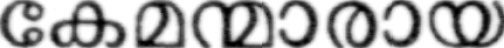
കേമന്മാരായ
